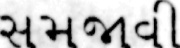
સમજાવી
